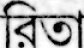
রিতা
